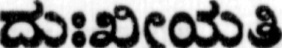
ದುಃಖೀಯತಿ
